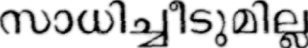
സാധിച്ചീടുമില്ല
